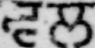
ਵਲ
